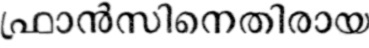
ഫ്രാന്‍സിനെതിരായ
